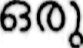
ഒരു
